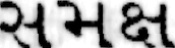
સમક્ષ
